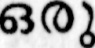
ഒരു
